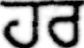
ਹਰ
